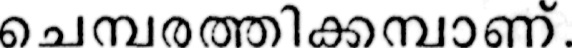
ചെമ്പരത്തിക്കമ്പാണ്.
